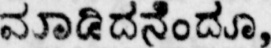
ಮಾಡಿದನೆಂದೂ,
